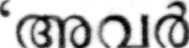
'അവര്‍
